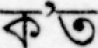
ক'ত
